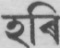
হৰি
